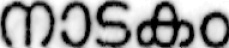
നാടകം
